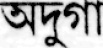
অদুগা
